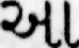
આ
